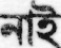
নাই
